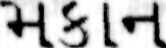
મકાન
